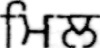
ਮਿਲ
